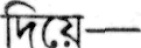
দিয়ে-
